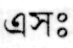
এসঃ
